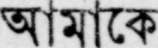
আমাকে
